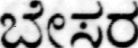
ಬೇಸರ
